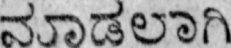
ಮಾಡಲಾಗಿ
